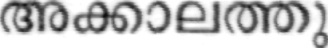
അക്കാലത്തു
